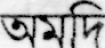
অমদি
